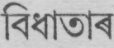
বিধাতাৰ
